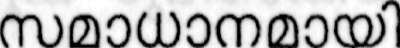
സമാധാനമായി
